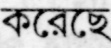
করেছে
